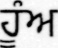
ਹੂੰਅ
